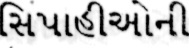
સિપાહીઓની
